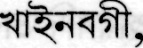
খাইনবগী,
